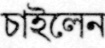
চাইলেন
